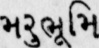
મરુભૂમિ
